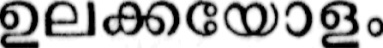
ഉലക്കയോളം
